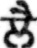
ਲੈ
